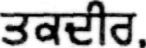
ਤਕਦੀਰ,
